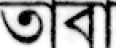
তাবা
